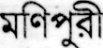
মণিপুরী
